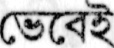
ভেবেই
